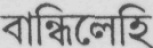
বান্ধিলেহি
